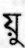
য়ু
